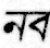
নব
